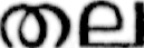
തല
